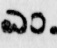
ಎಂ.
